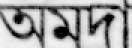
অমদা
